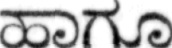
ಹಾಗೂ
